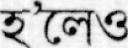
হ'লেও
